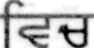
ਵਿਚ
